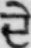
ਦੇ
